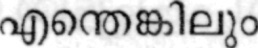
എന്തെങ്കിലും
